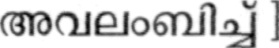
അവലംബിച്ച്]
